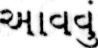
આવવું
